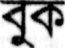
বুক
